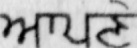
ਆਪਣੇ
